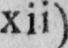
xii)
